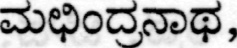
ಮಛಿಂದ್ರನಾಥ,
